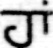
ਹਾਂ
